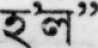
হ'ল"
